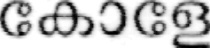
കോളേ
